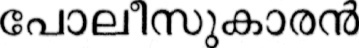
പോലീസുകാരന്‍
